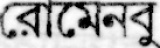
রোমেনবু
